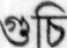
গুচি
